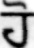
ਹੋ
